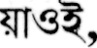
য়াওই,
